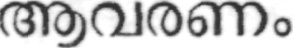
ആവരണം
